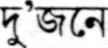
দু’জনে
